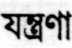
যন্ত্রণা
